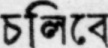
চলিবে
